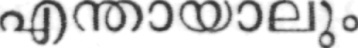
എന്തായാലും
